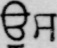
ਉਸ
